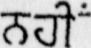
ਨਹੀਂ
